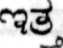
ಇತ್ತ
